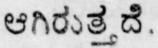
ಆಗಿರುತ್ತದೆ.
